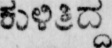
ಕುಳಿತಿದ್ದ
